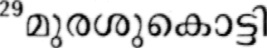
29മുരശുകൊട്ടി
